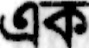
এক
